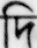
দি
